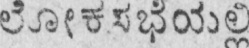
ಲೋಕಸಭೆಯಲ್ಲಿ
